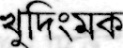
খুদিংমক
